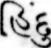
હિંદુ
